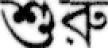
শুরু
